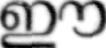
ഈ
